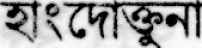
হাংদোক্তুনা
